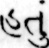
હતું
